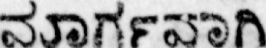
ಮಾರ್ಗವಾಗಿ
